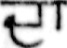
ਦਾ
